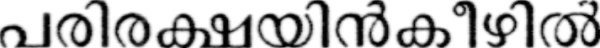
പരിരക്ഷയിന്‍കീഴില്‍
